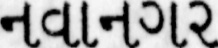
નવાનગર
